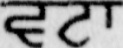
ਵਟਾ
